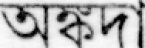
অঙ্কদা
